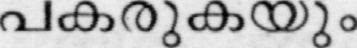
പകരുകയും
